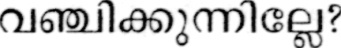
വഞ്ചിക്കുന്നില്ലേ?
